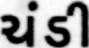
ચંડી
